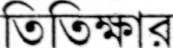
তিতিক্ষার
